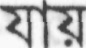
যায়
